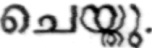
ചെയ്തു.
